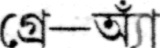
গ্রে–অ্যাঁ
